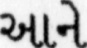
આને
